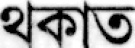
থকাত
